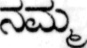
ನಮ್ಮ
